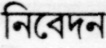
নিবেদন
